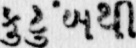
કુટુંબથી
